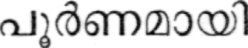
പൂര്‍ണമായി
